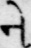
ને
